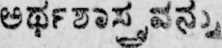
ಅರ್ಥಶಾಸ್ತ್ರವನ್ನು
